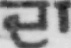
ਦਾ
